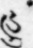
હું
